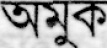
অমুক
